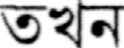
তখন
